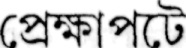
প্রেক্ষাপটে
